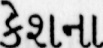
કેશના
